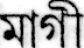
মাগী
